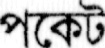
পকেট
